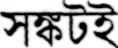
সঙ্কটই
